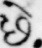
છે.
